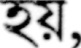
হয়,
